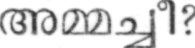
അമ്മച്ചീ?
